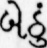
બેઠું
